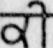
ਕੀ
